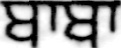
ਬਾਬਾ
